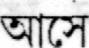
আসে
